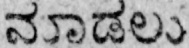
ಮಾಡಲು
